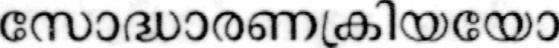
സോദ്ധാരണക്രിയയോ
